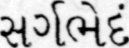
સર્ગભેદં
